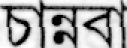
চান্নবা
